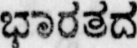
ಭಾರತದ
